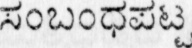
ಸಂಬಂಧಪಟ್ಟ
